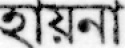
হায়না
